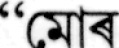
"মোৰ
